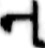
ન
